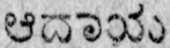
ಆದಾಯ
